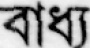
বাধ্য
